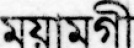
ময়ামগী
